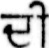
ਦੀ
